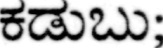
ಕಡುಬು;
